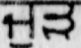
ਜੁੜ
